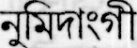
নুমিদাংগী
